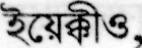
ইয়েক্কীও,
